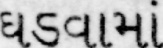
ઘડવામાં
